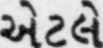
એટલે
